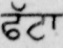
ਫੱਟਾ
